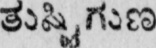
ತುಷ್ಟಿಗುಣ
